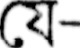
যে-
